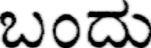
ಬಂದು
